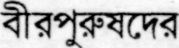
বীরপুরুষদের
